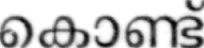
കൊണ്ട്
